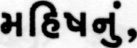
મહિષનું,
